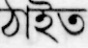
ঠাইত
